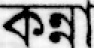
কন্না
